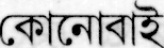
কোনোবাই
